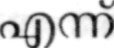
എന്ന്
